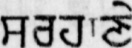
ਸਰਹਾਣੇ
